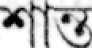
শান্ত
